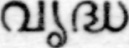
വൃദ്ധ
